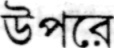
উপরে
